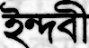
ইন্দবী
